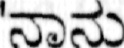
‘ನಾನು
